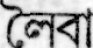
লৈবা
